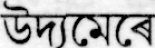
উদ্যমেৰে
